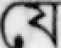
যে
